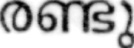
രണ്ടു
